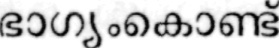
ഭാഗ്യംകൊണ്ട്
